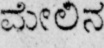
ಮೇಲಿನ
